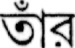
তাঁর
